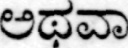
ಅಥವಾ
